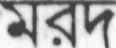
মরদ
